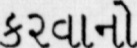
કરવાનો
